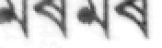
মৰমৰ
